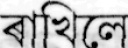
ৰাখিলে
